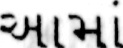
આમાં
